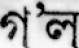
গ'ল
